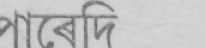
পাৰেদি
